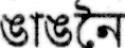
ঙাঙনৈ
